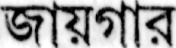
জায়গার
